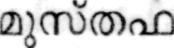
മുസ്തഫ
